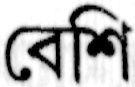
বেশি
